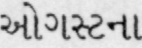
ઓગસ્ટના
